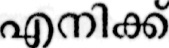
എനിക്ക്
